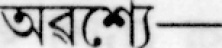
অৱশ্যে-
